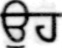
ਉਹ
